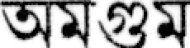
অমগুম
